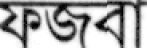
ফজবা
